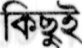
কিছুই
